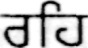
ਰਹਿ
